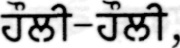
ਹੌਲੀ-ਹੌਲੀ,
